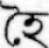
হৈ
